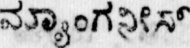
ಮ್ಯಾಂಗನೀಸ್
